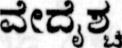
ವೇದೈಶ್ಚ
